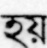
হয়
